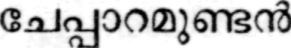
ചേപ്പാറമുണ്ടന്‍
